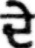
ਦੇ
